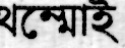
থম্মোই
